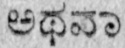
ಅಥವಾ
